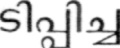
ടിപ്പിച്ച
